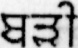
ਬੜੀ
